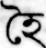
হৈ
